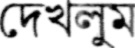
দেখলুম
